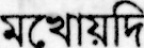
মখোয়দি
